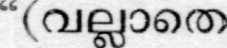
"(വല്ലാതെ
